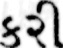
કરી
